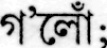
গ'লোঁ;
